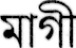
মাগী
